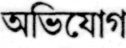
অভিযোগ
